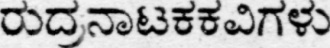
ರುದ್ರನಾಟಕಕವಿಗಳು
